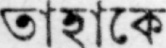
তাহাকে
